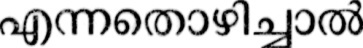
എന്നതൊഴിച്ചാല്‍
